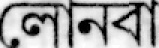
লোনবা
